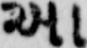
આ
